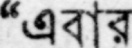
‘‘এবার
